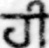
ਹੀ
